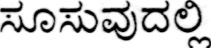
ಸೂಸುವುದಲ್ಲಿ
